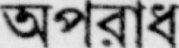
অপরাধ
